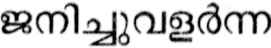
ജനിച്ചുവളര്‍ന്ന
